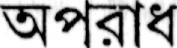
অপরাধ
